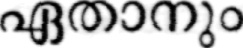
ഏതാനും
